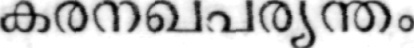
കരനഖപര്യന്തം
